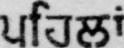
ਪਹਿਲਾਂ
